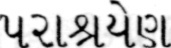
પરાશ્રયેણ
